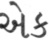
એક
